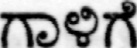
ಗಾಳಿಗೆ
